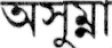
অসুম্না
